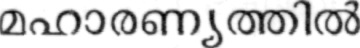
മഹാരണ്യത്തില്‍
